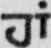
ਹਾਂ
